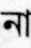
না
